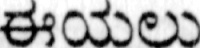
ಈಯಲು
